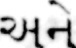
અને
